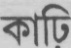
কাঢ়ি
